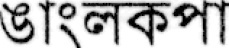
ঙাংলকপা
